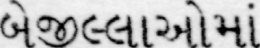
બેજીલ્લાઓમાં
